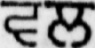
ਵਲ
